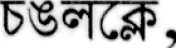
চঙলক্লে,
